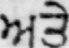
ਅਤੇ
